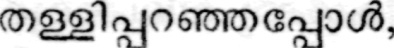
തള്ളിപ്പറഞ്ഞപ്പോള്‍,
